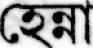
হেন্না
